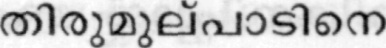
തിരുമുല്പാടിനെ
